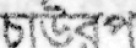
চাউরপ
